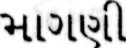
માગણી
